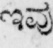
ಇವು
